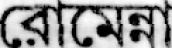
রোমেন্না
